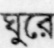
ঘুরে
